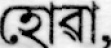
হোৱা,
